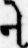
ને
